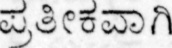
ಪ್ರತೀಕವಾಗಿ
